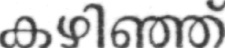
കഴിഞ്ഞ്
